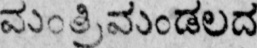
ಮಂತ್ರಿಮಂಡಲದ
